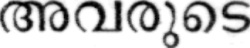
അവരുടെ
